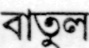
বাতুল
